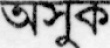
অসুক
